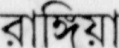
রাঙ্গিয়া
